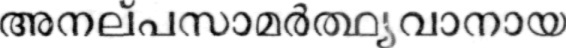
അനല്പസാമര്‍ത്ഥ്യവാനായ
